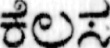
ಕೆಲಸ
